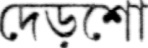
দেড়শো
